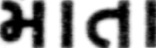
માતા
